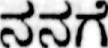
ನನಗೆ
